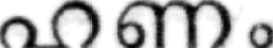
ഹണം
